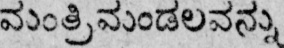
ಮಂತ್ರಿಮಂಡಲವನ್ನು
